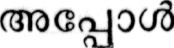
അപ്പോള്‍
